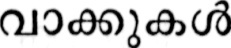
വാക്കുകള്‍
